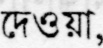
দেওয়া,
